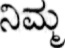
ನಿಮ್ಮ
